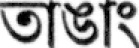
তাঙাং
